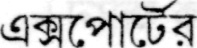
এক্সপোর্টের
